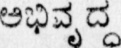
ಅಭಿವೃದ್ಧ
